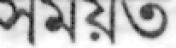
সময়ত
